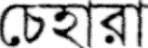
চেহারা
